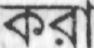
করা
